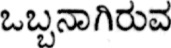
ಒಬ್ಬನಾಗಿರುವ
